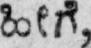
ಹೀಗೆ,
